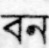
বন
